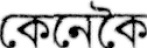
কেনেকৈ
